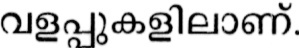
വളപ്പുകളിലാണ്.
